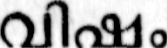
വിഷം
